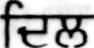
ਦਿਲ
